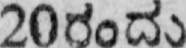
20ರಂದು
